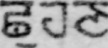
ਛੁਹਣ
